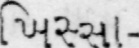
ખિસ્સા-
